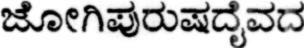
ಜೋಗಿಪುರುಷದೈವದ
